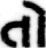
તો
